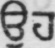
ਉਹ
